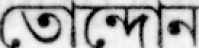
তোন্দোন
